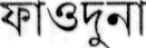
ফাওদুনা
